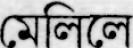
মেলিলে
